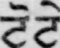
ਟੋਟੇ
